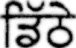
ਡਿੱਠੇ
